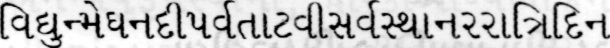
વિદ્યુન્મેઘનદીપર્વતાટવીસર્વસ્થાનરરાત્રિદિન
